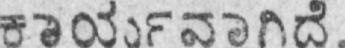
ಕಾರ್ಯವಾಗಿದೆ.
